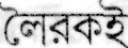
লৈরকই
